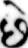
છે
